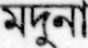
মদুনা
